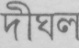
দীঘল
